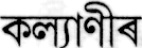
কল্যাণীৰ
